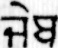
ਜੇਬ
